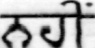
ਨਹੀਂ
